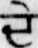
ਦੇ
